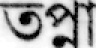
তপ্না
